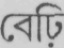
বেঢ়ি
